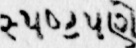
સ્પષ્ટપણે
